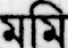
মমি
